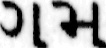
ગમ
